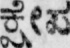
ಕ್ಷೇಪ
